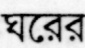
ঘরের
